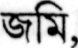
জমি,
